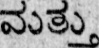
ಮತ್ತು
